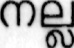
നല്ല
